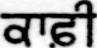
ਕਾਫ਼ੀ
